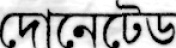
দোনেটেড
